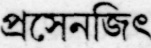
প্রসেনজিত্
